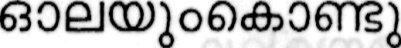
ഓലയുംകൊണ്ടു
